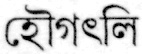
হৌগৎলি
